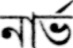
নার্ভ
